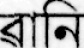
ৱানি
